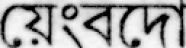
য়েংবদো
